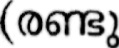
(രണ്ടു
